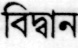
বিদ্বান
